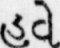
હવે
